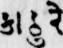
કાઠુરે
